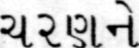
ચરણને
